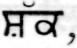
ਸ਼ੱਕ,
